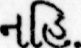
નહિ.
